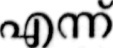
എന്ന്
